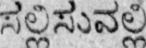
ಸಲ್ಲಿಸುವಲ್ಲಿ
